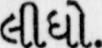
લીધો.
